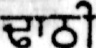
ਢਾਠੀ
